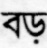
বড়
